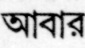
আবার
